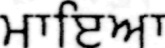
ਮਾਇਆ
